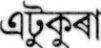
এটুকুৰা
